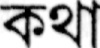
কথা
